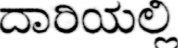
ದಾರಿಯಲ್ಲಿ
